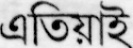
এতিয়াই
